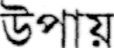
উপায়
